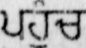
ਪਹੁੰਚ
